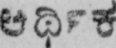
ಆರ್ಥಿಕ
